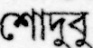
শোদুবু
